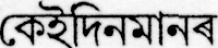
কেইদিনমানৰ
